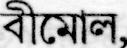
বীমোল,
